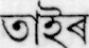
তাইৰ
